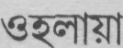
ওহলায়া
